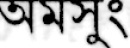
অমসুং
